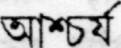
আশ্চর্য
